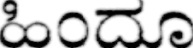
ಹಿಂದೂ
